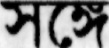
সঙ্গে
